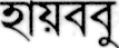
হায়ববু
